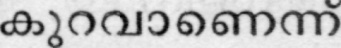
കുറവാണെന്ന്
